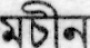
মচীন
